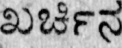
ಖರ್ಚಿನ
